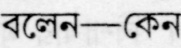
বলেন–কেন
